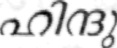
ഹിന്ദു
